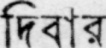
দিবার
